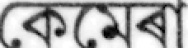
কেমেৰা
